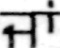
ਜਾਂ
